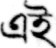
এই
